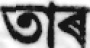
তাৰ
